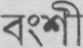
বংশী
